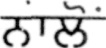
ਨਾਲੋਂ
